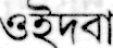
ওইদবা
